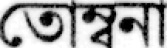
তোম্বনা
